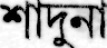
শাদুনা
